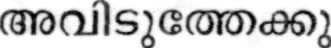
അവിടുത്തേക്കു
